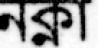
নক্না
